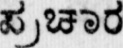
ಪ್ರಚಾರ
